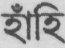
হাঁহি
